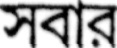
সবার
